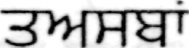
ਤਅਸਬਾਂ
